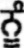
ਨੂੰ
